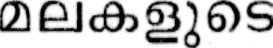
മലകളുടെ
